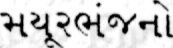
મયૂરભંજનો
